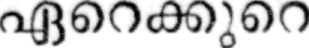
ഏറെക്കുറെ
